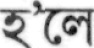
হ'লে
